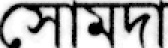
সোমদা
